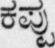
ಕಪ್ಪು
